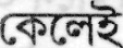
কেলেই
